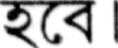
হবে।
